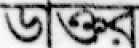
ডাক্তর
